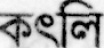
কৎলি
